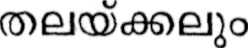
തലയ്ക്കലും
